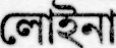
লোইনা
